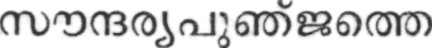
സൌന്ദര്യപുഞ്ജത്തെ
